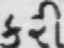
કરી
